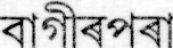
বাগীৰপৰা
